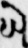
બે
